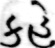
કહે
